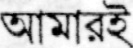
আমারই
